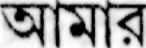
আমার
